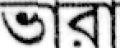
ভারা
